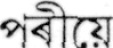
পৰীয়ে
